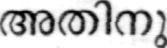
അതിനു
